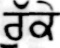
ਰੁੱਕੇ
